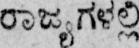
ರಾಜ್ಯಗಳಲ್ಲಿ
